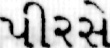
પીરસે
